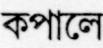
কপালে
